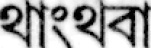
থাংথবা
